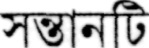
সন্তানটি
